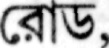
রোড,
